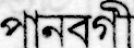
পানবগী
